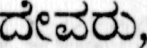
ದೇವರು,
